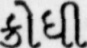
ક્રોધી
